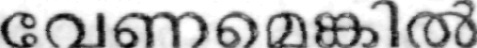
വേണമെങ്കില്‍
